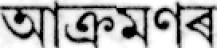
আক্রমণৰ
